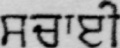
ਸਚਾਈ
